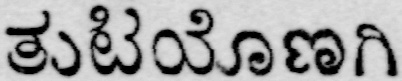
ತುಟಿಯೊಣಗಿ
